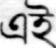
এই
